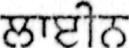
ਲਾਈਨ
